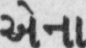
એના
